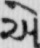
એ
